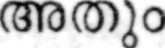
അതും
